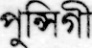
পুন্সিগী
